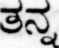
ತನ್ನ
